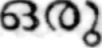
ഒരു
